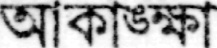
আকাঙ্ক্ষা
